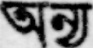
অন্য
